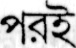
পরই
